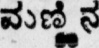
ಮಣ್ಣಿನ
